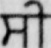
ਸੀ
